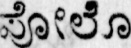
ಪೋಲೊ
